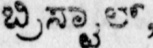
ಬ್ರಿಸ್ಟಾಲ್,
